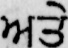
ਅਤੇ
